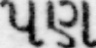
પણ
